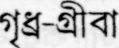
গৃধ্র-গ্রীবা
